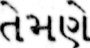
તેમણે
